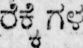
ರೆಕ್ಕೆಗಳ
